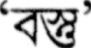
‘বস্তু'
